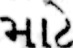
માટે
